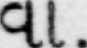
વા.
